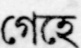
গেহে
